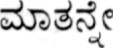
ಮಾತನ್ನೇ
